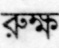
রুক্ষ
